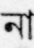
না
